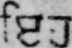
ਇਹ
